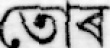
তোৰ
